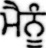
ਮੈਨੂੰ
